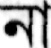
না
